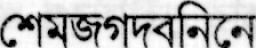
শেমজগদবনিনে
